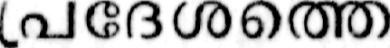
പ്രദേശത്തെ
